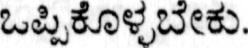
ಒಪ್ಪಿಕೊಳ್ಳಬೇಕು.
